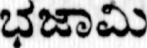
ಭಜಾಮಿ
